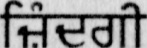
ਜ਼ਿੰਦਗੀ
